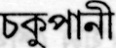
চকুপানী
